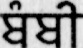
ਬੰਬੀ
